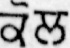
ਕੋਲ
